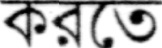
করতে
